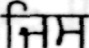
ਜਿਸ
